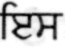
ਇਸ
